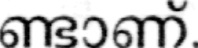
ണ്ടാണ്.
